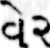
વેર
